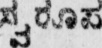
ಸ್ವರೂಪ
